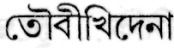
তৌবীখিদেনা
